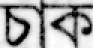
চাক
